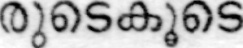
രുടെകൂടെ
